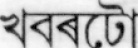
খবৰটো
